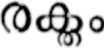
രക്തം
